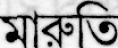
মারুতি
